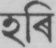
হৰি
